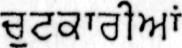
ਚੁਟਕਾਰੀਆਂ
